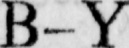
B-Y
